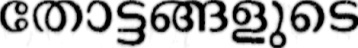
തോട്ടങ്ങളുടെ
